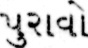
પુરાવો
